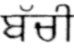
ਬੱਚੀ
